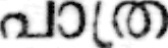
പാത്ര
